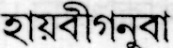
হায়বীগনুবা
